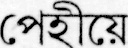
পেহীয়ে
